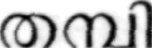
തമ്പി
